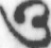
ও
